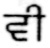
ਵੀ
